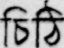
চিঠি
